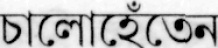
চালোহেঁতেন
